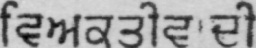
ਵਿਅਕਤੀਵਾਦੀ
